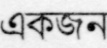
একজন
